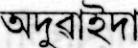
অদুৱাইদা
